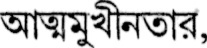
আত্মমুখীনতার,
